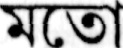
মতো
